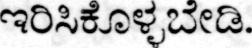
ಇರಿಸಿಕೊಳ್ಳಬೇಡಿ.
